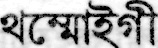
থম্মোইগী
